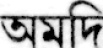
অমদি
